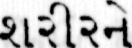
શરીરને
